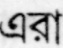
এরা
